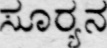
ಸೂರ್‍ಯನ
